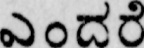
ಎಂದರೆ
